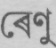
ৰেণু
